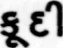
કૂદી
